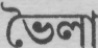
ভৈলা
